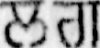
ਲਗ
